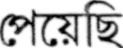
পেয়েছি
